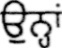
ਉਨ੍ਹਾਂ
